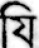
যি
